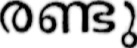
രണ്ടു
